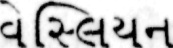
વેસ્લિયન
